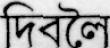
দিবলৈ
